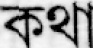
কথা
